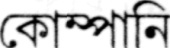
কোম্পানি
